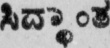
ಸಿದ್ಧಾಂತ
